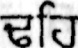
ਢਹਿ
